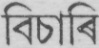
বিচাৰি
